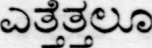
ಎತ್ತೆತ್ತಲೂ
